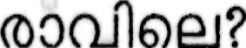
രാവിലെ?
